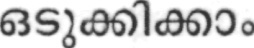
ഒടുക്കിക്കാം
